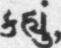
કહ્યું,
